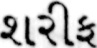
શરીફ
